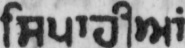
ਸਿਪਾਹੀਆਂ
